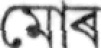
মোৰ
